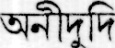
অনীদুদি
